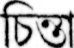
চিন্তা
